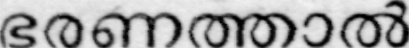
ഭരണത്താല്‍
